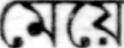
মেয়ে
